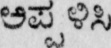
ಅಪ್ಪಳಿಸಿ
